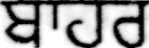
ਬਾਹਰ
